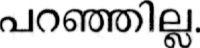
പറഞ്ഞില്ല.
